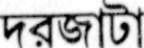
দরজাটা
